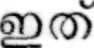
ഇത്
